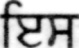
ਇਸ
